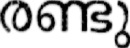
രണ്ടു
